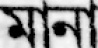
মানা
